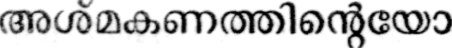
അശ്മകണത്തിന്റെയോ
